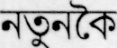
নতুনকৈ
